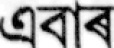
এবাৰ
